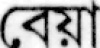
বেয়া
